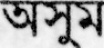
অসুম
